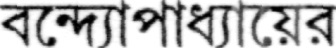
বন্দ্যোপাধ্যায়ের
